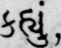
કહ્યું,
